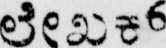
ಲೇಖಕ್
